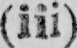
(iii)
